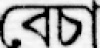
বেচা
